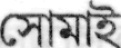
সোমাই
